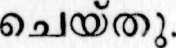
ചെയ്തു.
